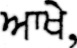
ਆਖੇ,
